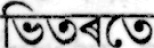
ভিতৰতে
